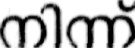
നിന്ന്
